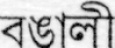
বঙালী
